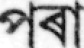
পৰা
